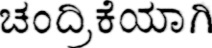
ಚಂದ್ರಿಕೆಯಾಗಿ
